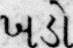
ખડો
